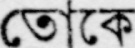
তোকে
